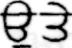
ਉਤੇ
